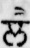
ਲੈ
